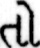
તો
